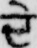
ਦੇ
